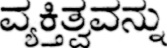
ವ್ಯಕ್ತಿತ್ವವನ್ನು
